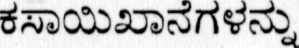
ಕಸಾಯಿಖಾನೆಗಳನ್ನು
